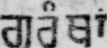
ਗਰੰਥਾਂ
